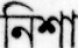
নিশা
